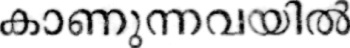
കാണുന്നവയില്‍
